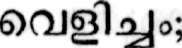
വെളിച്ചം;
